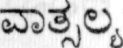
ವಾತ್ಸಲ್ಯ
